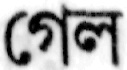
গেল
